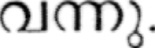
വന്നു.
